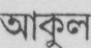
আকুল
